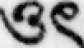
ওৎ
